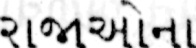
રાજાઓના
